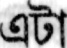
এটা
